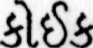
કોઈક
